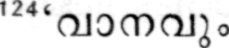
124'വാനവും
